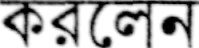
করলেন
